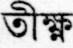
তীক্ষ্ণ
